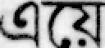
এয়ে
